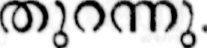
തുറന്നു.
